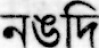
নঙদি
